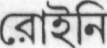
রোইনি
